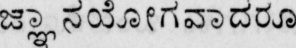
ಜ್ಞಾನಯೋಗವಾದರೂ
